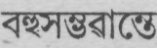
বহুসম্ভৱান্তে
